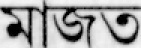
মাজত
